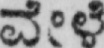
ವೇಳೆ
